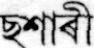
ছশাৰী
